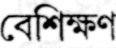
বেশিক্ষণ
